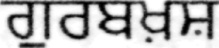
ਗੁਰਬਖ਼ਸ਼
